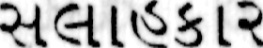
સલાહકાર
